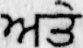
ਅਤੇ
